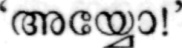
'അയ്യോ!'
